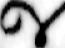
જ
